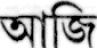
আজি
